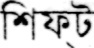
শিফ্ট
